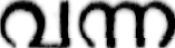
വന്ന
